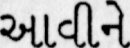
આવીને
